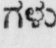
ಗಳು
